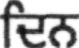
ਦਿਨ
